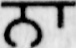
ਨਾ
